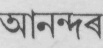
আনন্দৰ
